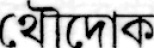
থৌদোক
